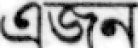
এজন
